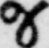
જ
